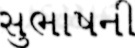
સુભાષની
